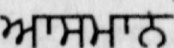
ਆਸਮਾਨ
